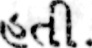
હતી.
